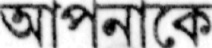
আপনাকে
